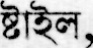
ষ্টাইল,
